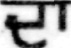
ਦਾ
